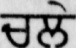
ਚਲੇ
